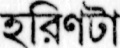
হরিণটা
